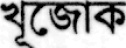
খূজোক
